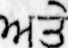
ਅਤੇ
